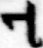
ન
